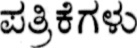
ಪತ್ರಿಕೆಗಳು
